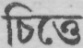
চিত্তে
